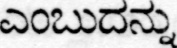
ಎಂಬುದನ್ನು
